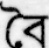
বৈ
